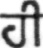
ਹੀ
